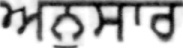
ਅਨੁਸਾਰ
